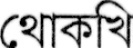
থোকখি
